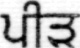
ਪੀੜ
